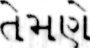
તેમણે
